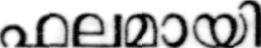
ഫലമായി
